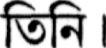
তিনি।
